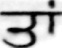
ਤਾਂ
